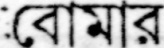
বোমার
